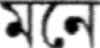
মনে
